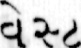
વેસ્ટ
